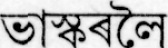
ভাস্কৰলৈ
